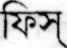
ফিস্
